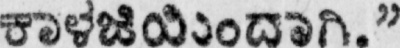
ಕಾಳಜಿಯಿಂದಾಗಿ.”
